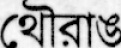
থৌরাঙ
